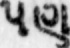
પણ
